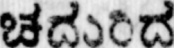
ಚದುರಿದ
